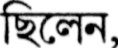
ছিলেন,
